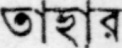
তাহার
